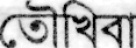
তৌখিবা
